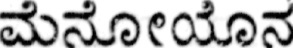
ಮೆನೋಯೊನ
